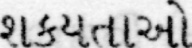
શક્યતાઓ
